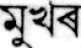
মুখৰ
